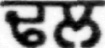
ਢਲ
